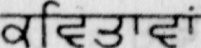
ਕਵਿਤਾਵਾਂ
